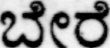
ಬೇರೆ
